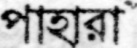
পাহারা
